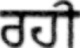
ਰਹੀ
